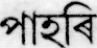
পাহৰি
